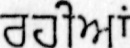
ਰਹੀਆਂ
